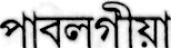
পাবলগীয়া
